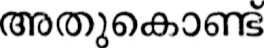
അതുകൊണ്ട്
